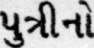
પુત્રીનો
